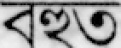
বহুত
